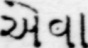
એવા
